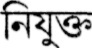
নিযুক্ত
